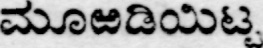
ಮೂಱಡಿಯಿಟ್ಟ
